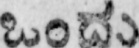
ಒಂದು
